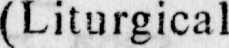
(Liturgical
